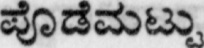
ಪೊಡೆಮಟ್ಟು
